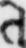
તે
